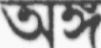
অঙ্গ
